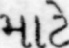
માટે
